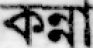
কন্না
